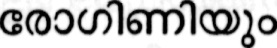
രോഗിണിയും
